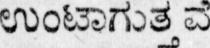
ಉಂಟಾಗುತ್ತವೆ
